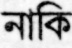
নাকি
